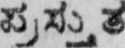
ಪ್ರಸ್ತುತ
